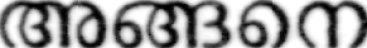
അങ്ങനെ
